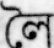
লৈ
